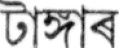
টাঙ্গাৰ
